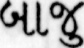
બાજુ
